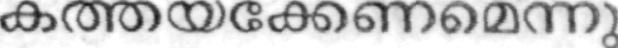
കത്തയക്കേണമെന്നു
